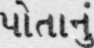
પોતાનું
